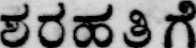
ಶರಹತಿಗೆ
